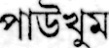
পাউখুম
